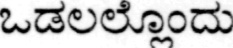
ಒಡಲಲ್ಲೊಂದು
